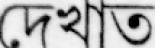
দেখাত
